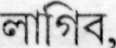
লাগিব,
